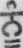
ਨੂੰ
